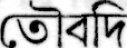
তৌবদি
